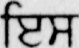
ਇਸ
